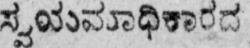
ಸ್ವಯಮಾಧಿಕಾರದ
